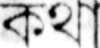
কথা
